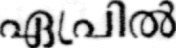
ഏപ്രില്‍
